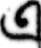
এ
